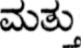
ಮತ್ತು
